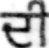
ਦੀ
